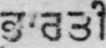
ਭਾਰਤੀ
